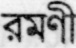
রমণী
